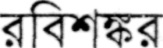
রবিশঙ্কর
